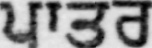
ਪਾਤਰ
